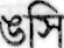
ঙসি
